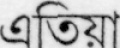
এতিয়া
